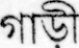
গাড়ী
